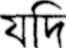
যদি
